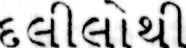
દલીલોથી
